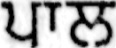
ਪਾਲ
